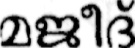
മജീദ്
